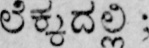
ಲೆಕ್ಕದಲ್ಲಿ;
